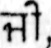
ਜੀ,
